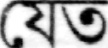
যেত
